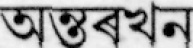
অন্তৰখন
